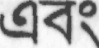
এবং
